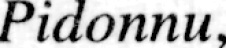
Pidonnu,
